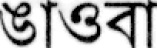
ঙাওবা
